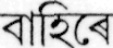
বাহিৰে
